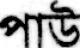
পাউ
